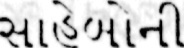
સાહેબોની
